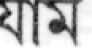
যাম
